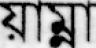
য়াম্না
